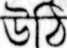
উঠি
